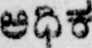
ಅಧಿಕ
